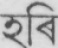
হৰি
